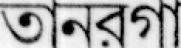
তানরগা
